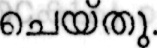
ചെയ്തു.
